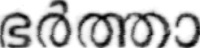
ഭര്‍ത്താ
